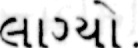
લાગ્યો.
